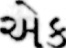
એક
